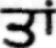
ਤਾਂ
